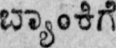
ಬ್ಯಾಂಕಿಗೆ
